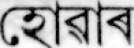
হোৱাৰ
